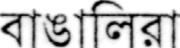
বাঙালিরা
